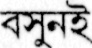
বসুনই
